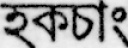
হকচাং
